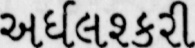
અર્ધલશ્કરી
